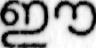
ഈ
